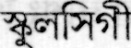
স্কুলসিগী
